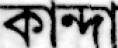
কান্দা
